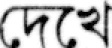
দেখে
